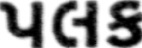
પલક
